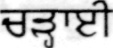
ਚੜ੍ਹਾਈ
